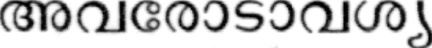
അവരോടാവശ്യ
